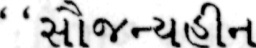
"સૌજન્યહીન
